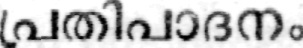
പ്രതിപാദനം
